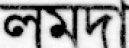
লমদা
